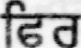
ਫਿਰ
